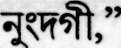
নুংদগী,”
